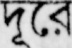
দূরে
